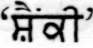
'ਸ਼ੈਂਕੀ'
